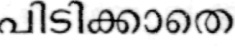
പിടിക്കാതെ
